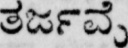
ತರ್ಜವ್ರೆ
